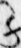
કે
